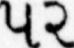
પર
